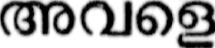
അവളെ
